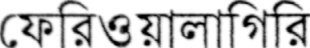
ফেরিওয়ালাগিরি
